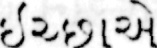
ઇચ્છાએ
